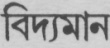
বিদ্যমান
